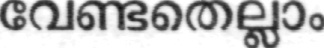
വേണ്ടതെല്ലാം
